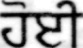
ਹੋਈ
